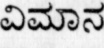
ವಿಮಾನ
